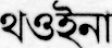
থওইনা
